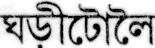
ঘড়ীটোলৈ
